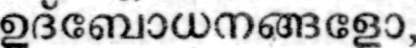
ഉദ്ബോധനങ്ങളോ,
